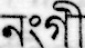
নংগী
